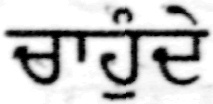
ਚਾਹੁੰਦੇ
